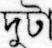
দুটা
